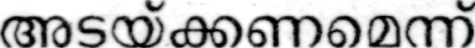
അടയ്ക്കണമെന്ന്
